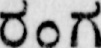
ರಂಗ
